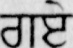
ਗਏ
